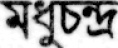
মধুচন্দ্র
